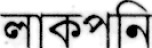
লাকপনি
